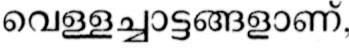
വെള്ളച്ചാട്ടങ്ങളാണ്,
